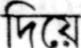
দিয়ে
